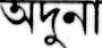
অদুনা
